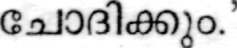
ചോദിക്കും.’
